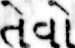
તેવો
